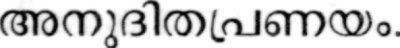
അനുദിതപ്രണയം.
